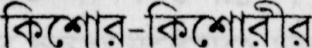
কিশোর-কিশোরীর
